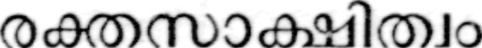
രക്തസാക്ഷിത്വം
